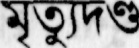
মৃত্যুদণ্ড
